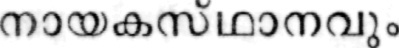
നായകസ്ഥാനവും
